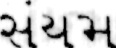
સંયમ
